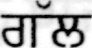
ਗੱਲ
